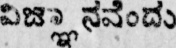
ವಿಜ್ಞಾನವೆಂದು
